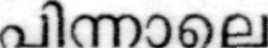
പിന്നാലെ
